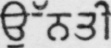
ਉੱਨਤੀ
